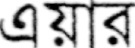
এয়ার
